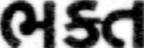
ભક્ત
